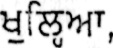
ਖੁਲ੍ਹਿਆ,
